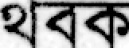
থবক
